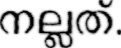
നല്ലത്.
